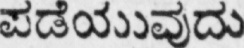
ಪಡೆಯುವುದು
